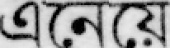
এনেয়ে
